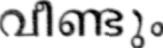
വീണ്ടും
